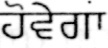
ਹੋਵੇਗਾ
